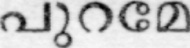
പുറമേ
